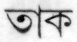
তাক
